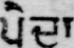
ਪੈਦਾ
